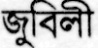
জুবিলী
